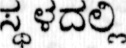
ಸ್ಥಳದಲ್ಲಿ
